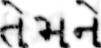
તેમને
